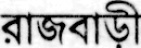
রাজবাড়ী
